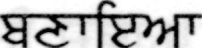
ਬਣਾਇਆ
